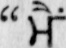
''ਮੈਂ
